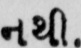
નથી.
